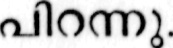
പിറന്നു.
